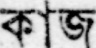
কাজ
